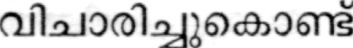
വിചാരിച്ചുകൊണ്ട്
